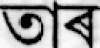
তাৰ
